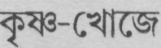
কৃষ্ণ-খোজে
